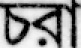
চরা
